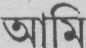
আমি
